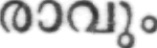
രാവും
